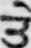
ਤੇ
